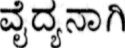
ವೈದ್ಯನಾಗಿ
